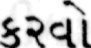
કરવો
